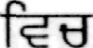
ਵਿਚ
